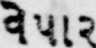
વેપાર
